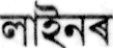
লাইনৰ
